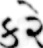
કરે
